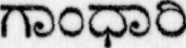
ಗಾಂಧಾರಿ
